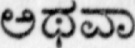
ಅಥವಾ
